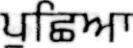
ਪੁਛਿਆ
